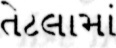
તેટલામાં
